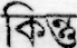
কিন্তু
